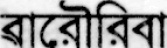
ৱারৌরিবা
